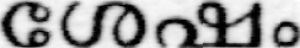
ശേഷം
